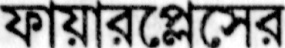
ফায়ারপ্লেসের
